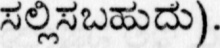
ಸಲ್ಲಿಸಬಹುದು).
